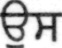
ਉਸ
